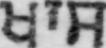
ਖਾਸ
